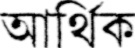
আর্থিক
